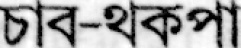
চাব-থকপা
